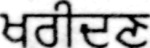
ਖਰੀਦਣ
